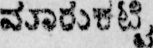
ಮಾರುಕಟ್ಟೆ
